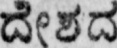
ದೇಶದ
